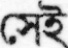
সেই
